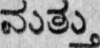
ಮತ್ತು
